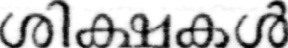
ശിക്ഷകള്‍
